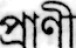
প্রাণী
